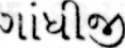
ગાંધીજી
